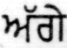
ਅੱਗੇ
